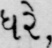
ધરે,
